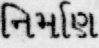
નિર્માણ
